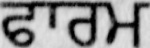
ਫਾਰਮ
